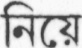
নিয়ে
